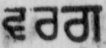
ਵਰਗ
